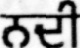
ਨਦੀ
